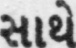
સાથે
